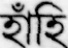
হাঁহি
